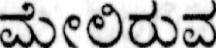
ಮೇಲಿರುವ
